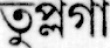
তুপ্লগা
